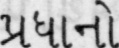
પ્રધાનો
